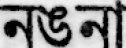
নঙনা
